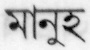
মানুহ
